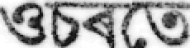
ওচৰতে
